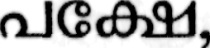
പക്ഷേ,
